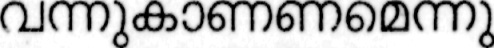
വന്നുകാണണമെന്നു
